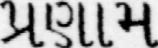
પ્રણામ
